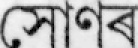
সোণৰ
